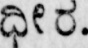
ಧೀರ.
